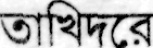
তাখিদরে
